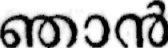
ഞാന്‍
